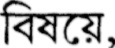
বিষয়ে,
